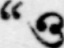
‘‘ও
